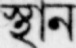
স্থান
